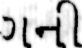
ગની
